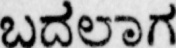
ಬದಲಾಗ
